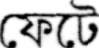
ফেটে
